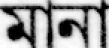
মানা
